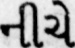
નીચે
